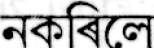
নকৰিলে
